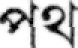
পথ
